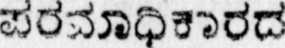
ಪರಮಾಧಿಕಾರದ
